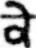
ਕੇ
